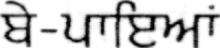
ਬੇ-ਪਾਇਆ
